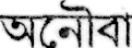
অনৌবা
